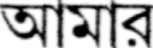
আমার
